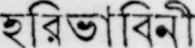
হরিভাবিনী
